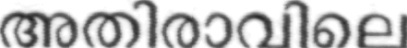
അതിരാവിലെ
